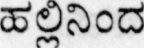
ಹಲ್ಲಿನಿಂದ
